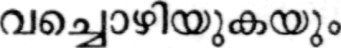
വച്ചൊഴിയുകയും
